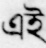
এই
